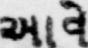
આવે
